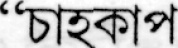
"চাহকাপ
